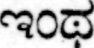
ಇಂಥ
